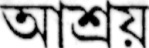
আশ্রয়
